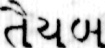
તૈયબ
